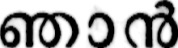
ഞാന്‍
